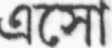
এসো
